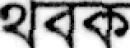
থবক
